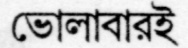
ভোলাবারই
